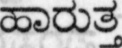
ಹಾರುತ್ತ
